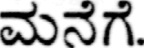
ಮನೆಗೆ.
